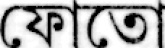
ফোতো
